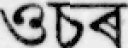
ওচৰ
